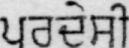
ਪਰਦੇਸੀ
